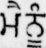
ਮੈਨੂੰ
